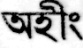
অহীং
